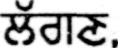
ਲੱਗਣ,
